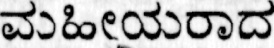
ಮಹೀಯರಾದ
